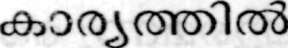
കാര്യത്തില്‍
